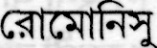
রোমোনিসু
